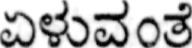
ಏಳುವಂತೆ
